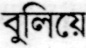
বুলিয়ে
